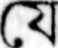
যে
